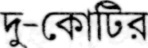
দু-কোটির
